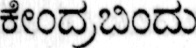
ಕೇಂದ್ರಬಿಂದು
